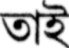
তাই
